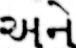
અને
